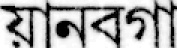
য়ানবগা
